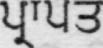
ਪ੍ਰਾਪਤ
